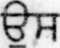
ਉਸ
